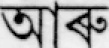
আৰু
